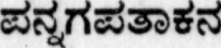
ಪನ್ನಗಪತಾಕನ
